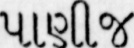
પાણીજ
